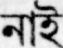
নাই
